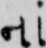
નાં
